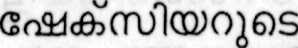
ഷേക്സിയറുടെ
